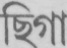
ছিগা
